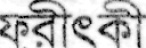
ফূরীৎকী
